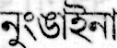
নুংঙাইনা
